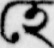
হে
